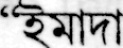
“ইমাদা
